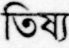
তিষ্য
